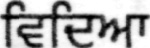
ਵਿਦਿਆ
